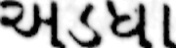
અડધા
